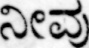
ನೀವು
